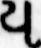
ય
